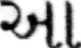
આ
